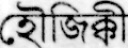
হৌজিক্কী
